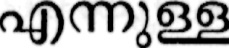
എന്നുള്ള
